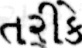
તરીકે
